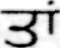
ਤਾਂ
